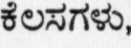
ಕೆಲಸಗಳು,
